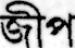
জীপ
